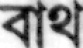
বাথ
